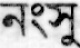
নংসু
